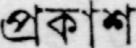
প্রকাশ
